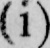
(i)
